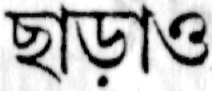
ছাড়াও
